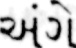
અંગે
